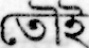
তৌই
